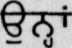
ਉਨ੍ਹਾਂ
